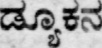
ಡ್ಯೂಕನ
